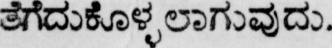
ತೆಗೆದುಕೊಳ್ಳಲಾಗುವುದು.
